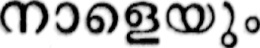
നാളെയും
